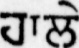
ਹਾਲੇ
